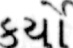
કર્યો
